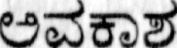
ಅವಕಾಶ
